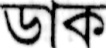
ডাক
